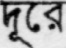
দূরে
